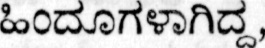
ಹಿಂದೂಗಳಾಗಿದ್ದ,
